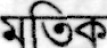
মতিক
